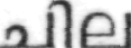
ചില
